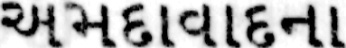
અમદાવાદના
